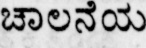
ಚಾಲನೆಯ
